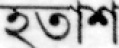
হতাশ
